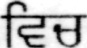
ਵਿਚ
